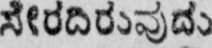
ಸೇರದಿರುವುದು
